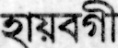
হায়বগী
